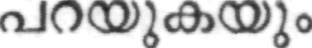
പറയുകയും
